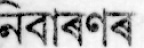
নিবাৰণৰ
